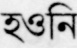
হওনি
